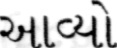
આવ્યો
